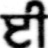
ਈ
